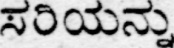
ಸರಿಯನ್ನು
